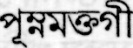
পূম্নমক্তগী
